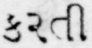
કરતી
